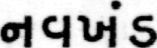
નવખંડ
